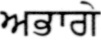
ਅਭਾਗੇ
